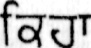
ਕਿਹਾ
